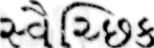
સ્વૈચ્છિક
